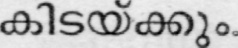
കിടയ്ക്കും.
